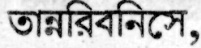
তান্নরিবনিসে,
